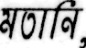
মতানি,
